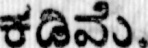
ಕಡಿಮೆ.
